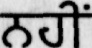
ਨਹੀਂ
